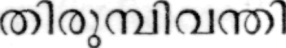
തിരുമ്പിവന്തി
